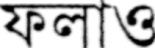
ফলাও
